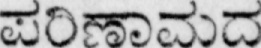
ಪರಿಣಾಮದ
